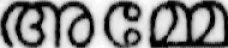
അമ്മേ
